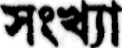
সংখ্যা
